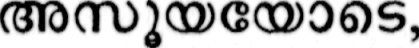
അസൂയയോടെ,
